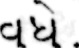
વધે.
